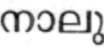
നാലു
